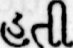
હતી
